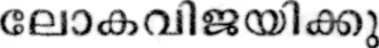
ലോകവിജയിക്കു
